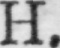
H.
